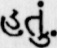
હતું.
